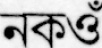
নকওঁ
